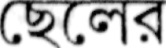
ছেলের
